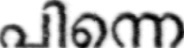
പിന്നെ
